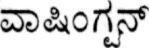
ವಾಷಿಂಗ್ಟನ್
